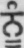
ਨੂੰ
